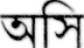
অসি
